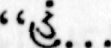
"હં...
